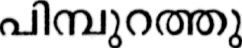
പിമ്പുറത്തു
